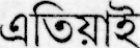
এতিয়াই
